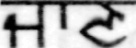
ਜਾਣ
